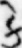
કે
